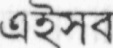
এইসব
